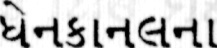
ધેનકાનલના
